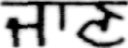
ਜਾਣ
